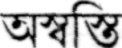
অস্বস্তি
